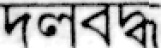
দলবদ্ধ
